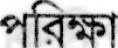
পরিক্ষা
